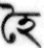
হৈ
